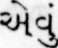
એવું
